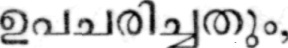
ഉപചരിച്ചതും,
